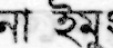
ইমু
